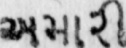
અમારી
